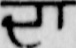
ਦਾ
